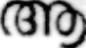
ആ
